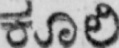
ಕೂಲಿ
